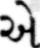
એ
